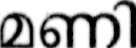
മണി
